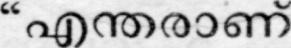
"എന്തരാണ്
